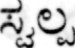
ಸ್ವಲ್ಪ
